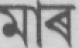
মাৰ
